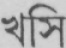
খসি
